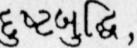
દુષ્ટબુદ્ધિ,
